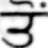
ਤੋਂ
